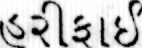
હરીફાઈ
